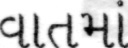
વાતમાં
